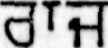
ਰਾਜ
